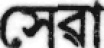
সেৱা
